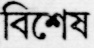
বিশেষ
